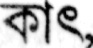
কাৎ,
